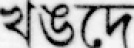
খঙদে
